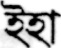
ইহা
